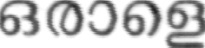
ഒരാളെ
